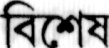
বিশেষ
